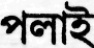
পলাই
